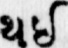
થઈ
